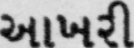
આખરી
